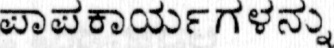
ಪಾಪಕಾರ್ಯಗಳನ್ನು
